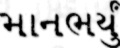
માનભર્યું
